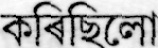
কৰিছিলো
